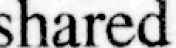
shared
